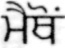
ਮੈਥੋਂ
